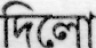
দিলো
